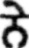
ਨੇ
